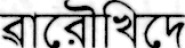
ৱারৌখিদে
